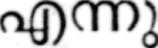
എന്നു
